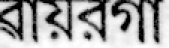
ৱায়রগা
